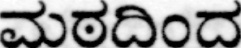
ಮಠದಿಂದ
